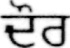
ਦੌਰ
